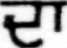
ਦਾ
